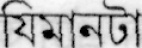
যিমানটা
